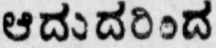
ಆದುದರಿಂದ
